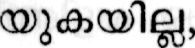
യുകയില്ല,
